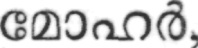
മോഹര്‍,
